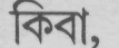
কিবা,
